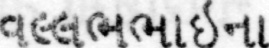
વલ્લભભાઈના
